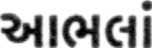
આભલાં
